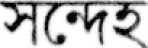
সন্দেহ
